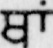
ਥਾਂ
